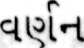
વર્ણન
